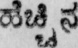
ಹೆಚ್ಚಿನ
